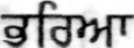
ਭਰਿਆ
